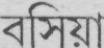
বসিয়া
